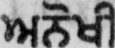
ਅਨੋਖੀ
